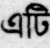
এটি
